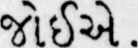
જોઈએ.
